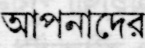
আপনাদের
